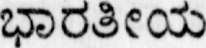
ಭಾರತೀಯ
